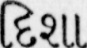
દિશા
